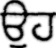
ਉਹ
